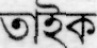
তাইক
